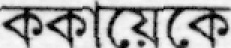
ককায়েকে
